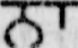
ਨਾ
